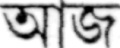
আজ
